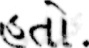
હતો.
